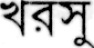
খরসু
